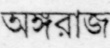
অঙ্গরাজ
